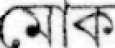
মোক
